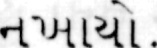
નખાયો.
